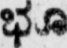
ಭೂ
